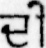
ਦੀ
